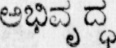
ಅಭಿವೃದ್ಧ
